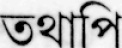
তথাপি
